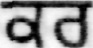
ਕਰ
